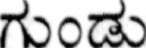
ಗುಂಡು
